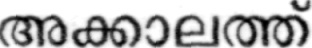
അക്കാലത്ത്
